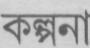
কল্পনা
